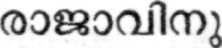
രാജാവിനു
